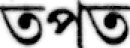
তপত
